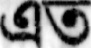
এত
